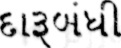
દારૂબંધી
